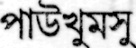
পাউখুমসু
